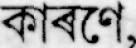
কাৰণে,
